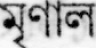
মৃণাল
